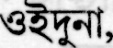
ওইদুনা,
